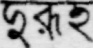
দুরূহ
